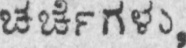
ಚರ್ಚೆಗಳು,
